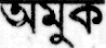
অমুক
